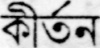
কীর্তন
